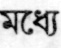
মধ্যে
